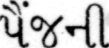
પૈંજની
